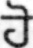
ਹੋ
